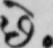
છે.
